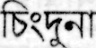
চিংদুনা
